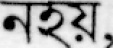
নহয়,
